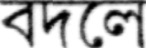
বদলে
